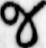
જ
